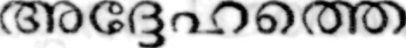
അദ്ദേഹത്തെ
